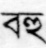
বহু
